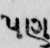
પણ
